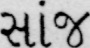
સાંજ
